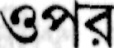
ওপর
